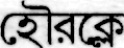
হৌরক্লে
